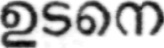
ഉടനെ
